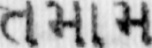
તમામ
